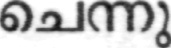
ചെന്നു
